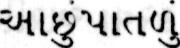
આછુંપાતળું
